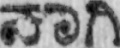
ವಾಗಿ
